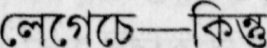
লেগেচে-কিন্তু
